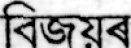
বিজয়ৰ
